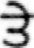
ਤੇ
